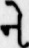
ને
